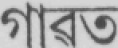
গাৱত
